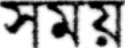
সময়
